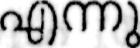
എന്നു
